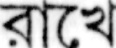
রাখে
